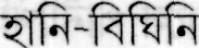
হানি-বিঘিনি
